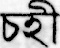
চহী
